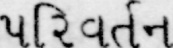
પરિવર્તન
